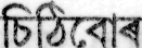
চিঠিবোৰ
